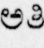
ಅತಿ
